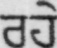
ਰਹੇ
